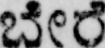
ಬೇರೆ
